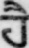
ਹੈ
